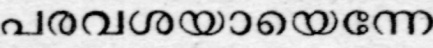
പരവശയായെന്നേ
